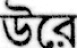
উরে
